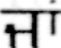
ਜਾਂ
